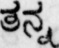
ತನ್ನ
